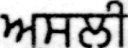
ਅਸਲੀ
